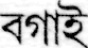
বগাই
